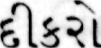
દીકરો
